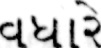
વધારે
